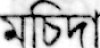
মচিদা
